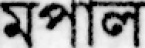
মপাল
